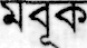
মবূক
